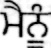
ਮੈਨੂੰ
